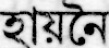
হায়নৈ
